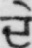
ਦੇ
